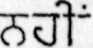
ਨਹੀਂ
